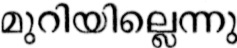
മുറിയില്ലെന്നു
